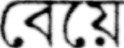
বেয়ে
